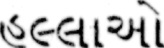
હલ્લાઓ
